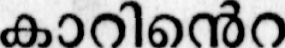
കാറിന്റെ
